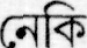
নেকি
